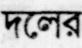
দলের
